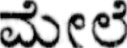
ಮೇಲೆ
